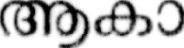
ആകാ
